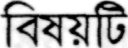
বিষয়টি
